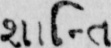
શાન્તિ
